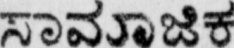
ಸಾಮಾಜಿಕ
